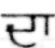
ਦਾ
